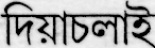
দিয়াচলাই
